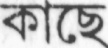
কাছে
